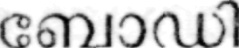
ബോഡി
